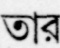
তার
